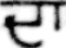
ਦਾ
